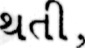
થતી,
